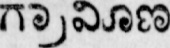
ಗ್ರಾಮೀಣ
